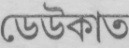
ডেউকাত
